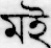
মই
